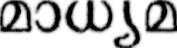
മാധ്യമ
